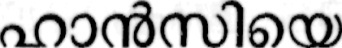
ഹാന്‍സിയെ
